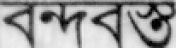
বন্দবস্ত
